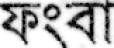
ফংবা
